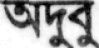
অদুবু
